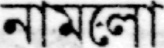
নামলো
